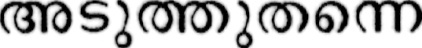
അടുത്തുതന്നെ
